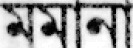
মমানা
